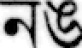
নঙ
